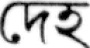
দেহ
